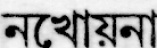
নখোয়না
